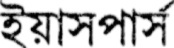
ইয়াসপার্স
